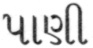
પાણી
